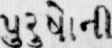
પુરુષોની
